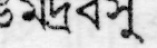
ঙমদ্রবসু
